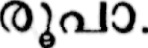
രൂപാ.
